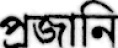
প্রজানি
